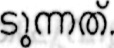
ടുന്നത്.
